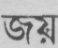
জয়
